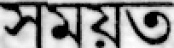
সময়ত
